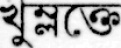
খুম্লক্তে
